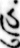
હું
